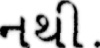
નથી.
